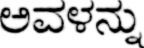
ಅವಳನ್ನು
